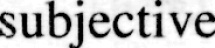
subjective
